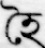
হৈ
